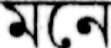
মনে
